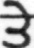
ਤੇ
